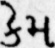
કેમ
